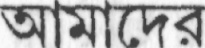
আমাদের
